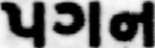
પગન
